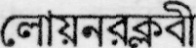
লোয়নরক্লবী
